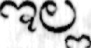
ಇಲ್ಲ
